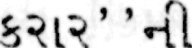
કરાર"ની
